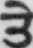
ਤੇ
